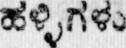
ಹಳ್ಳಿಗಳು
